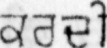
ਕਰਦੀ
